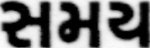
સમય
